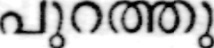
പുറത്തു
